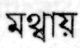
মথ্বায়
